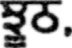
ਝੂਠ,
